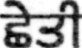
ਛੇਤੀ
